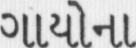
ગાયોના
